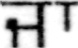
ਜਾਂ
